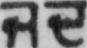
ਜਦ
